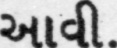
આવી.
